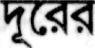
দূরের
